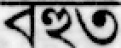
বহুত
